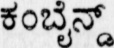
ಕಂಬೈನ್ಡ್
